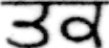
ਤਕ
